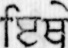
ਇਥੇ
